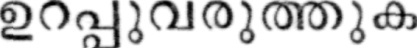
ഉറപ്പുവരുത്തുക
